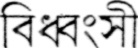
বিধ্বংসী
